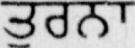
ਤੁਰਨਾ
